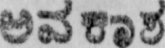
ಅವಕಾಶ
